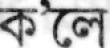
ক'লে
